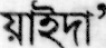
য়াইদা’
